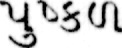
પુષ્કળ
